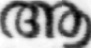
ആ
